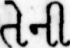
તેની
